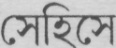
সেহিসে
